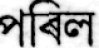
পৰিল
